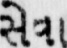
સેવા
